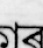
কাৰ
